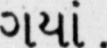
ગયાં.
